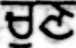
ਚੁਣ
